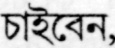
চাইবেন,
